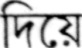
দিয়ে
